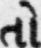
તો
